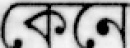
কেনে
